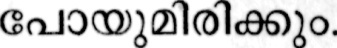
പോയുമിരിക്കും.
